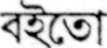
বইতো
